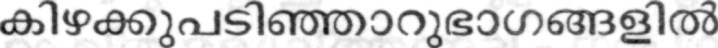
കിഴക്കുപടിഞ്ഞാറുഭാഗങ്ങളില്‍
